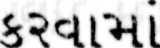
કરવામાં
